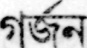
গর্জন
